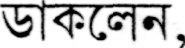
ডাকলেন,
